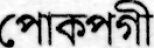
পোকপগী
